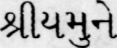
શ્રીયમુને
